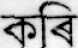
কৰি
